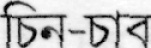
চিন-চাব
